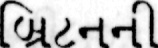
બ્રિટનની
